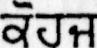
ਕੋਹਜ
